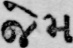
જેમ
